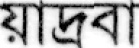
য়াদ্রবা
